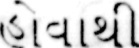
હોવાથી
